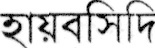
হায়বসিদি
